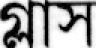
গ্লাস
